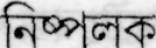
নিষ্পলক
